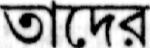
তাদের
